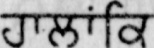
ਹਾਲਾਂਕਿ
